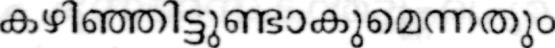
കഴിഞ്ഞിട്ടുണ്ടാകുമെന്നതും
